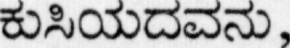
ಕುಸಿಯದವನು,
